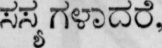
ಸಸ್ಯಗಳಾದರೆ,
